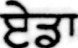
ਏਡਾ
